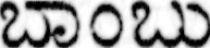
ಬಾಂಬು
